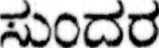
ಸುಂದರ
